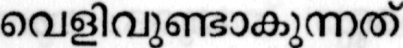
വെളിവുണ്ടാകുന്നത്
